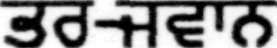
ਭਰ-ਜਵਾਨ
